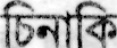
চিনাকি
